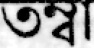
তম্বা
